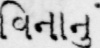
વિનાનું
